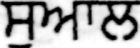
ਸੁਆਲ
